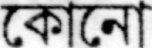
কোনো
